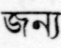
জন্য
